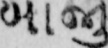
બાજુ
